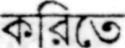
করিতে
